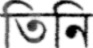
তিনি
